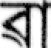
ৱা
